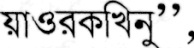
য়াওরকখিনু”,
